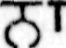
ਨਾ
